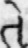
તે
